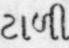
ટાળી
